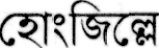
হোংজিল্লে
